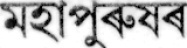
মহাপুৰুষৰ
